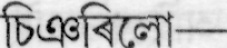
চিঞৰিলো-
